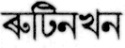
ৰুটিনখন
